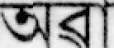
অৱা
